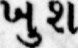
ખુશ
